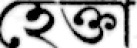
হেক্তা
